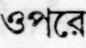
ওপরে
